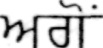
ਅਗੋਂ
